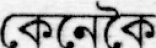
কেনেকৈ
